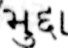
મુદ્દા
